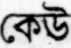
কেউ
